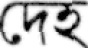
দেহ
